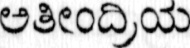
ಅತೀಂದ್ರಿಯ
